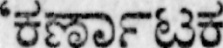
‘ಕರ್ಣಾಟಕ
